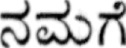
ನಮಗೆ
